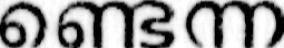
ണ്ടെന്ന
